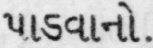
પાડવાનો.
